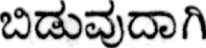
ಬಿಡುವುದಾಗಿ
